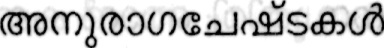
അനുരാഗചേഷ്ടകള്‍
